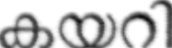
കയറി
